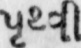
પૃથ્વી
